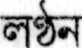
লণ্ঠন
